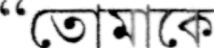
“তোমাকে
